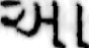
આ
